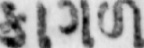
કાગળ
